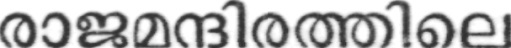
രാജമന്ദിരത്തിലെ
